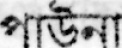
পাউনা
